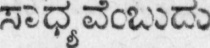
ಸಾಧ್ಯವೆಂಬುದು
